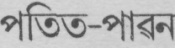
পতিত-পাৱন
